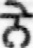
ਨੇ
